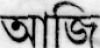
আজি
